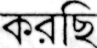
করছি
